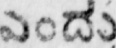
ಎಂದು
